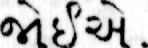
જોઇએ.
